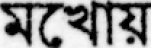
মখোয়
